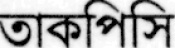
তাকপিসি
